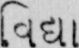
વિધા
